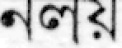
নলয়
